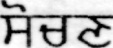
ਸੋਚਣ
